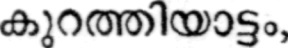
കുറത്തിയാട്ടം,
